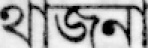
থাজনা
